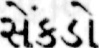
સેંકડો
